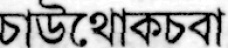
চাউথোকচবা
